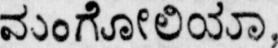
ಮಂಗೋಲಿಯಾ,
